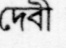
দেবী
